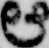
ಆ
